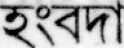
হংবদা
